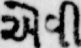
એવી
